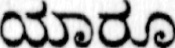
ಯಾರೂ
